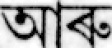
আৰু
